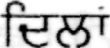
ਦਿਲਾਂ
